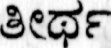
ತೀರ್ಥ
